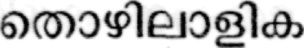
തൊഴിലാളിക
